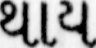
થાય
